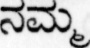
ನಮ್ಮ
